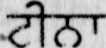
ਟੀਨਾ
